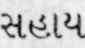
સહાય
